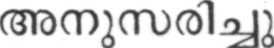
അനുസരിച്ചു
